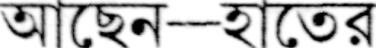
আছেন–হাতের
